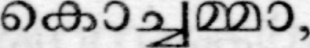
കൊച്ചമ്മാ,
